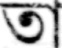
তা
